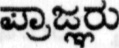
ಪ್ರಾಜ್ಞರು
